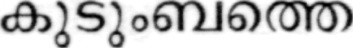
കുടുംബത്തെ
